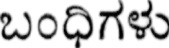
ಬಂಧಿಗಳು
